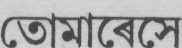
তোমাৰেসে
